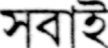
সবাই
